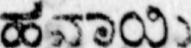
ಹವಾಯಿ
